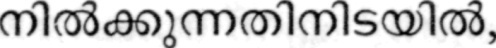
നില്‍ക്കുന്നതിനിടയില്‍,
